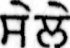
ਸੇਲੇ
